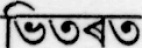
ভিতৰত
